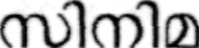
സിനിമ
